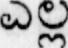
ಎಲ್ಲ
